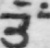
ਤੋਂ
